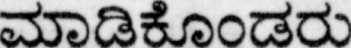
ಮಾಡಿಕೊಂಡರು
